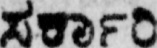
ಸರ್ಕಾರಿ
